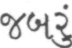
જબરું
